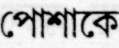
পোশাকে
